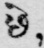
છે.
